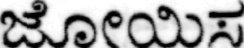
ಜೋಯಿಸ
